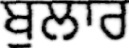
ਬੁਲਾਰ
